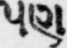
પણ
